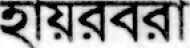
হায়রবরা
